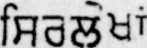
ਸਿਰਲੇਖਾਂ
